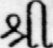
શ્રી
